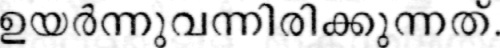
ഉയര്‍ന്നുവന്നിരിക്കുന്നത്.
